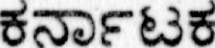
ಕರ್ನಾಟಕ
